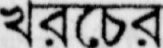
খরচের
